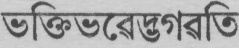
ভক্তিভৱেদ্ভগৱতি
